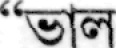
"ভাল
